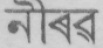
নীৰৱ
